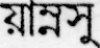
য়াম্নসু
